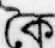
কৈ
